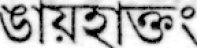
ঙায়হাক্তং
